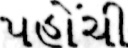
પહોંચી
